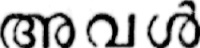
അവള്‍
